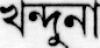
খন্দুনা
